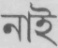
নাই
